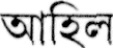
আহিল
